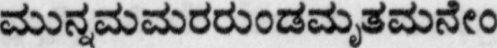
ಮುನ್ನಮಮರರುಂಡಮೃತಮನೇಂ
